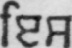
ਇਸ
